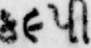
કલ્પી
